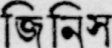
জিনিস
